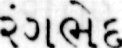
રંગભેદ
